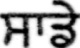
ਸਾਡੇ
